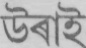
উৰাই
